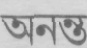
অনন্ত
